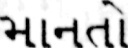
માનતો
